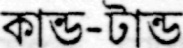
কান্ড-টান্ড
